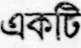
একটি
